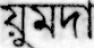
য়ুমদা
